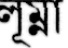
লূম্না
